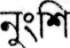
নুংশি
